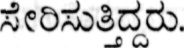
ಸೇರಿಸುತ್ತಿದ್ದರು.
